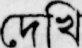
দেখি
